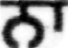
ਨਾ
